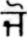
ਜੋ
